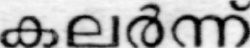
കലര്‍ന്ന്
